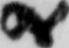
જ
